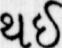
થઈ
